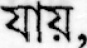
যায়,
